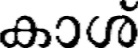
കാശ്
